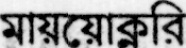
মায়য়োক্নরি
